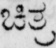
ಚಿತ್ರ
